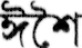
ঈশৈ
